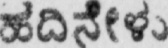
ಹದಿನೇಳು
